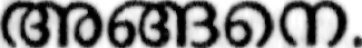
അങ്ങനെ.
